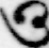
ও
